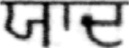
ਯਾਦ
